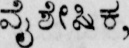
ವೈಶೇಷಿಕ,
